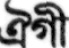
ঐগী
